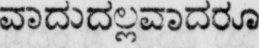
ವಾದುದಲ್ಲವಾದರೂ
